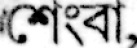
শেংবা,
